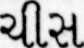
ચીસ
